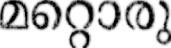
മറ്റൊരു
